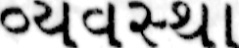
વ્યવસ્થા
